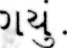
ગયું.
